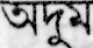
অদুম
